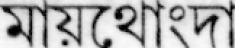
মায়থোংদা
